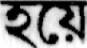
হয়ে
